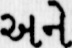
અને
